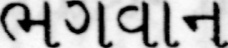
ભગવાન
